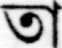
তা
